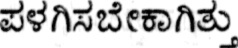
ಪಳಗಿಸಬೇಕಾಗಿತ್ತು
